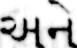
અને
